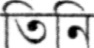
তিনি
